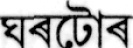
ঘৰটোৰ
